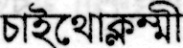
চাইথোক্লম্মী
